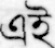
এই
